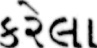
કરેલા
